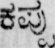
ಕಪ್ಪು
